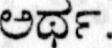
ಅರ್ಥ.
